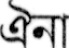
ঐনা
